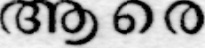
ആരെ
